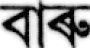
বাৰু
